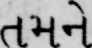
તમને
